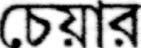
চেয়ার
